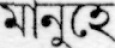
মানুহে
